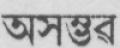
অসম্ভৱ
